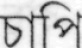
চাপি
